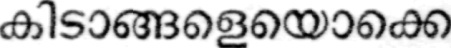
കിടാങ്ങളെയൊക്കെ
